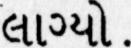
લાગ્યો.
